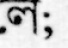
লৈ;
